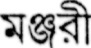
মঞ্জরী
